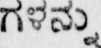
ಗಳನ್ನು
